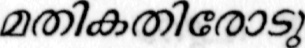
മതികതിരോടു
